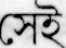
সেই
